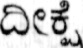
ದೀಕ್ಷೆ
